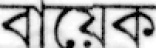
বায়েক
